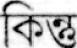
কিন্তু
